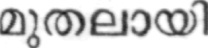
മുതലായി
